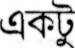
একটু
